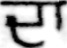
ਦਾ
